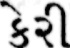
કેરી
